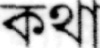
কথা
